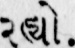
રહ્યો.
